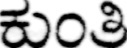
ಕುಂತಿ
